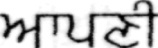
ਆਪਣੀ
